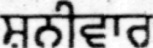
ਸ਼ਨੀਵਾਰ
